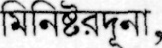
মিনিষ্টরদূনা,
